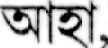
আহা,
